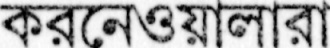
করনেওয়ালারা
